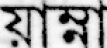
য়াম্না
